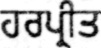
ਹਰਪ੍ਰੀਤ
